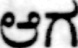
ಆಗ
